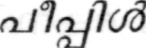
പീപ്പിള്‍
